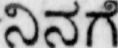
ನಿನಗೆ
